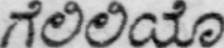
ಗೆಲಿಲಿಯೊ
